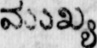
ಮುಖ್ಯ
